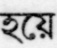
হয়ে
